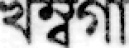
খম্বগা
